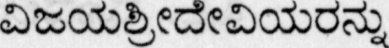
ವಿಜಯಶ್ರೀದೇವಿಯರನ್ನು
